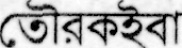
তৌরকইবা
